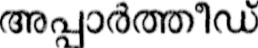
അപ്പാര്‍ത്തീഡ്
